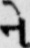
ને
